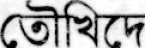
তৌখিদে
